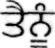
ਤੈਨੂੰ
